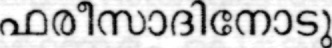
ഫരീസാദിനോടു
